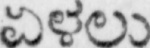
ಏಳಲು
